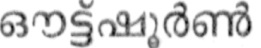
ഔട്ട്ഷൂര്‍ണ്‍
